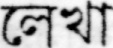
লেখা
